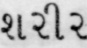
શરીર
